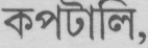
কপটালি,
